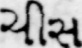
ચીસ
